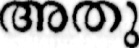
അതു
